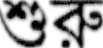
শুরু
